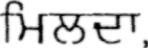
ਮਿਲਦਾ,
